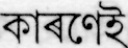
কাৰণেই
